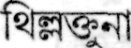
থিল্লক্তুনা
